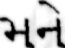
મને
